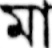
মা
